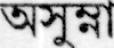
অসুম্না
